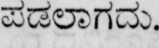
ಪಡಲಾಗದು.
